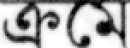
ক্রমে
